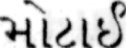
મોટાઈ
